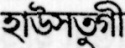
হাউসতুগী
